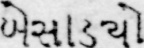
બેસાડ્યો
